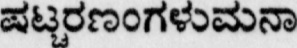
ಷಟ್ಟರಣಂಗಳುಮನಾ
